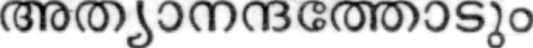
അത്യാനന്ദത്തോടും
